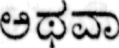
ಅಥವಾ
